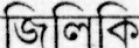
জিলিকি
